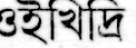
ওইখিদ্রি
